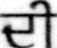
ਦੀ
